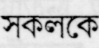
সকলকে
